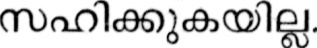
സഹിക്കുകയില്ല.
